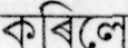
কৰিলে
